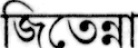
জিতেন্না
